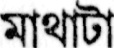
মাথাটা
